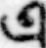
এ
